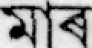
মাৰ
